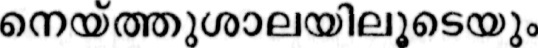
നെയ്ത്തുശാലയിലൂടെയും
